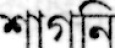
শাগনি
